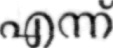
എന്ന്
